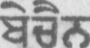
ਬੇਚੈਨ
